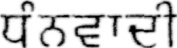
ਧੰਨਵਾਦੀ
